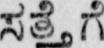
ಸತ್ತೆಗೆ
